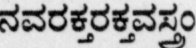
ನವರಕ್ತರಕ್ತವಸ್ತ್ರಂ
